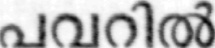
പവറില്‍
